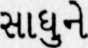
સાધુને
